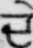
ਦੇ
